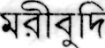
মরীবুদি
